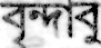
বৃন্দাবু
